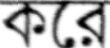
করে
